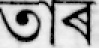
তাৰ
